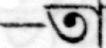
-তা
